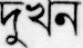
দুখন
